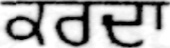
ਕਰਦਾ
